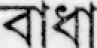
বাধা
